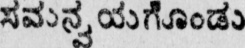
ಸಮನ್ವಯಗೊಂಡು
